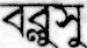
বব্লুসু
